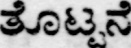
ತೊಟ್ಟನೆ
